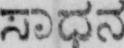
ಸಾಧನ
